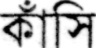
কাঁসি
